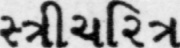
સ્ત્રીચરિત્ર
